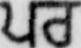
ਪਰ
